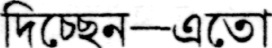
দিচ্ছেন–এতো
